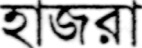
হাজরা
